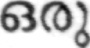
ഒരു
